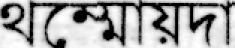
থম্মোয়দা
